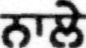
ਨਾਲੇ
